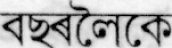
বছৰলৈকে
